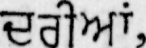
ਦਰੀਆਂ,
